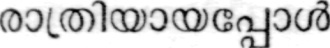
രാത്രിയായപ്പോള്‍
